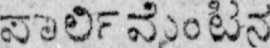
ಪಾರ್ಲಿಮೆಂಟಿನ
